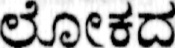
ಲೋಕದ
